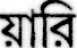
য়ারি
